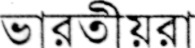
ভারতীয়রা
